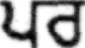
ਪਰ
